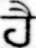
ਹੈ
